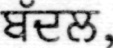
ਬੱਦਲ,
